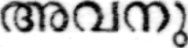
അവനു
